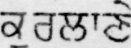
ਕੁਰਲਾਣੇ
